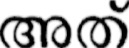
അത്
